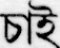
চাই
